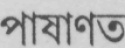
পাষাণত
